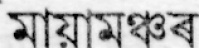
মায়ামঞ্চৰ
